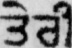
ਤੇਰੀ
